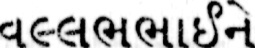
વલ્લભભાઈને
